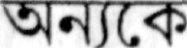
অন্যকে
